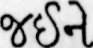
જઈને
